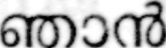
ഞാന്‍
